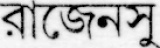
রাজেনসু
